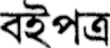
বইপত্র
